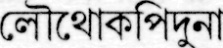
লৌথোকপিদুনা
